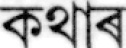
কথাৰ
